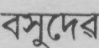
বসুদেৱ
